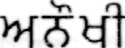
ਅਨੌਖੀ
